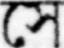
সে
